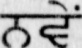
ਨਵੇਂ
